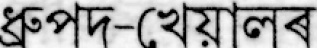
ধ্ৰুপদ-খেয়ালৰ
